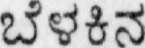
ಬೆಳಕಿನ
